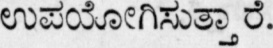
ಉಪಯೋಗಿಸುತ್ತಾರೆ.
